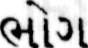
ભોગ
